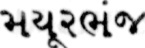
મૂયરભંજ
